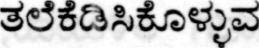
ತಲೆಕೆಡಿಸಿಕೊಳ್ಳುವ
